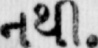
નથી.
